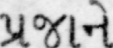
પ્રજાને
